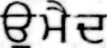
ਉਮੈਦ
